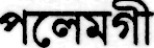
পলেমগী
